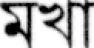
মখা
